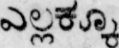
ಎಲ್ಲಕ್ಕೂ
